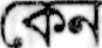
কেন
